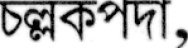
চল্লকপদা,
